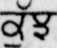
ਕੁੱਝ
